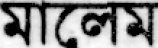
মালেম
